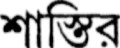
শাস্তির
